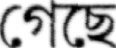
গেছে
